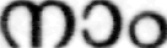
നാം
